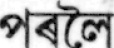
পৰলৈ
